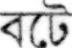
বটে
